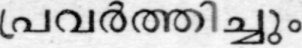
പ്രവര്‍ത്തിച്ചും
